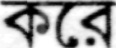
করে
